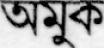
অমুক
